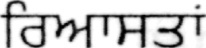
ਰਿਆਸਤਾਂ
